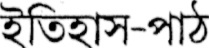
ইতিহাস-পাঠ
